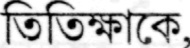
তিতিক্ষাকে,
